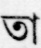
তা
